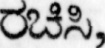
ರಚಿಸಿ,
